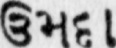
ઉમદા
